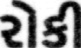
રોકી
